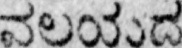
ವಲಯದ
